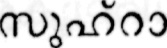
സുഹ്റാ
